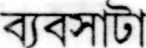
ব্যবসাটা
